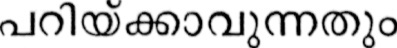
പറിയ്ക്കാവുന്നതും
